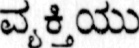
ವ್ಯಕ್ತಿಯು
